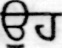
ਉਹ
